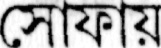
সোফায়
